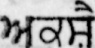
ਅਕਸ਼ੈ
